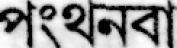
পংথনবা
